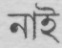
নাই
